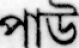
পাউ
